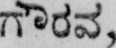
ಗೌರವ,
